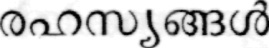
രഹസ്യങ്ങള്‍
